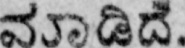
ಮಾಡಿದೆ.
